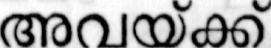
അവയ്ക്ക്
